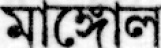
মাঙ্গোল
